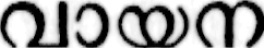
വായന
